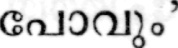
പോവും'
